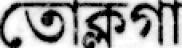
তোক্লগা
